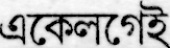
একেলগেই
